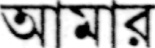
আমার
